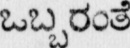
ಒಬ್ಬರಂತೆ
